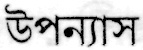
উপন্যাস
